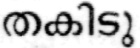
തകിടു
